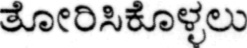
ತೋರಿಸಿಕೊಳ್ಳಲು
